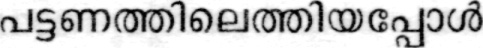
പട്ടണത്തിലെത്തിയപ്പോള്‍
